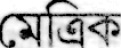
মেত্রিক
